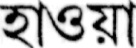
হাওয়া
